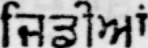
ਜਿਡੀਆਂ
